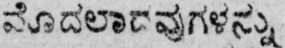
ಮೊದಲಾದವುಗಳನ್ನು
